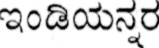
ಇಂಡಿಯನ್ನರ
